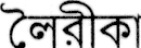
লৈরীকা
